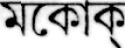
মকোক্
